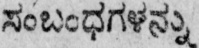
ಸಂಬಂಧಗಳನ್ನು
